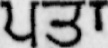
ਪਤਾ
